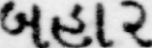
બહાર
